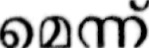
മെന്ന്
